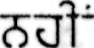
ਨਹੀਂ
